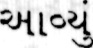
આવ્યું
